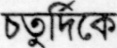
চতুর্দিকে
